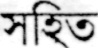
সহিত
